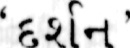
'દર્શન'
